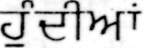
ਹੁੰਦੀਆਂ
